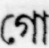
গো
